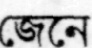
জেনে
